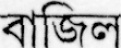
বাজিল
